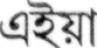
এইয়া
